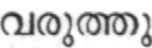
വരുത്തു
